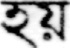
হয়
